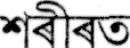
শৰীৰত
